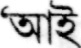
'আই
